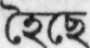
হৈছে
